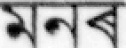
মনৰ
